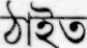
ঠাইত
